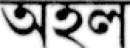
অহল
